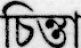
চিন্তা
